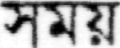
সময়
